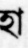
হা
